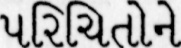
પરિચિતોને
